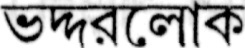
ভদ্দরলোক
